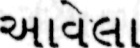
આવેલા
